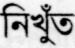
নিখুঁত
